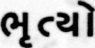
ભૃત્યો
